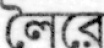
লৈরে
